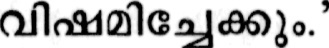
വിഷമിച്ചേക്കും.’
